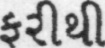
ફરીથી
